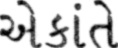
એકાંતે
